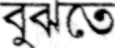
বুঝতে
